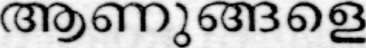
ആണുങ്ങളെ
